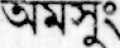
অমসুং
